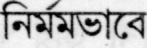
নির্মমভাবে
